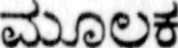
ಮೂಲಕ
